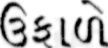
ઉફાળે
